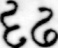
ર્દઢ
